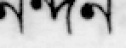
নন্দন
